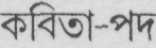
কবিতা-পদ
